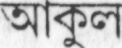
আকুল
